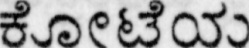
ಕೋಟೆಯ
